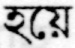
হয়ে
